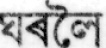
ঘৰলৈ
